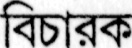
বিচারক
